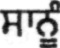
ਸਾਨੂੰ
